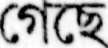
গেছে
